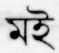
মই
